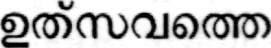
ഉത്സവത്തെ
